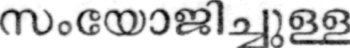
സംയോജിച്ചുള്ള
